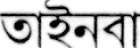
তাইনবা
